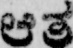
ಆತ
